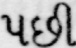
પછી
